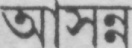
আসন্ন
